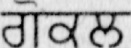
ਗੋਕਲ
